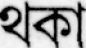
থকা
